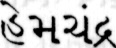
હેમચંદ્ર
